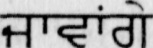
ਜਾਵਾਂਗੇ
